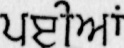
ਪਈਆਂ
